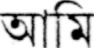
আমি
